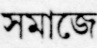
সমাজে
